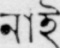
নাই
